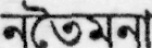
নতৈমনা
